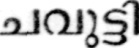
ചവുട്ടി
